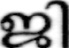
ജി
